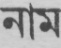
নাম
